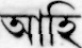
আহি
